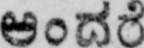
ಅಂದರೆ
